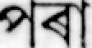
পৰা
